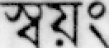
স্বয়ং
